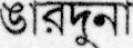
ঙারদুনা
